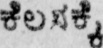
ಕೆಲಸಕ್ಕೆ
